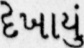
દેખાયું
